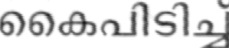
കൈപിടിച്ച്
